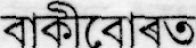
বাকীবোৰত
